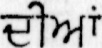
ਦੀਆਂ
